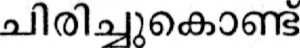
ചിരിച്ചുകൊണ്ട്
